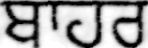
ਬਾਹਰ
